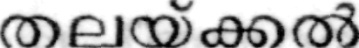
തലയ്ക്കല്‍
